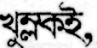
খুম্লকই,
